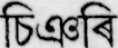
চিঞৰি
